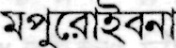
মপুরোইবনা
